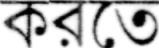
করতে
